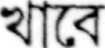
খাবে
